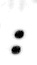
ঃ
